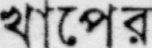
খাপের
